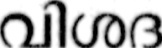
വിശദ
